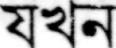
যখন
